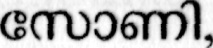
സോണി,
